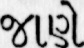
જાણે
